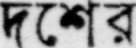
দশের
